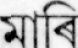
মাৰি
